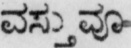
ವಸ್ತುವೂ
